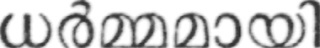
ധര്‍മ്മമായി
